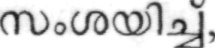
സംശയിച്ച്,
